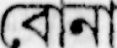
বোনা
